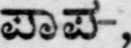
ಪಾಪ-,
